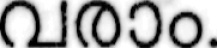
വരാം.
